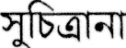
সুচিত্রানা
